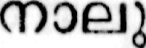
നാലു
